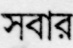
সবার
